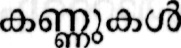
കണ്ണുകള്‍
